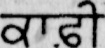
ਕਾਫ਼ੀ
